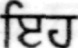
ਇਹ
